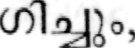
ഗിച്ചും,
